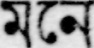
মনে
